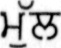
ਮੁੱਲ
